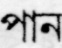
পান
